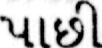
પાછી
